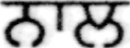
ਨਾਲ
